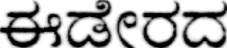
ಈಡೇರದ
